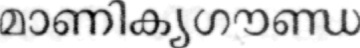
മാണിക്യഗൗണ്ഡ
